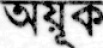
অয়ূক
